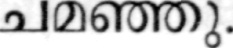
ചമഞ്ഞു.
